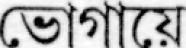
ভোগায়ে
